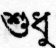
শুধু
